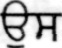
ਉਸ
